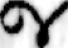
જ
